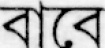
বাবে
